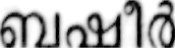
ബഷീര്‍
